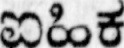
ಐಹಿಕ
